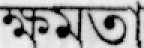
ক্ষমতা
